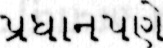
પ્રધાનપણે
